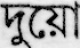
দুয়ো
